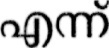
എന്ന്
